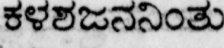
ಕಳಶಜನನಿಂತು
